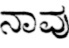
ನಾವು
